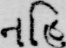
નહિ
